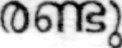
രണ്ടു
